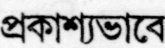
প্রকাশ্যভাবে
